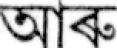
আৰু
